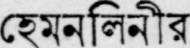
হেমনলিনীর
